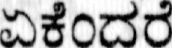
ಏಕೆಂದರೆ
